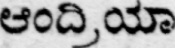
ಆಂದ್ರಿಯಾ
